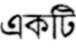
একটি
